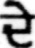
ਦੇ
